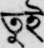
তুই
